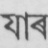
যাৰ
